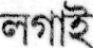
লগাই
